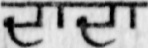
ਦਾਦਾ
